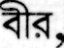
বীর,
